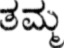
ತಮ್ಮ
